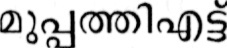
മുപ്പത്തിഎട്ട്
